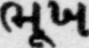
ભૂખ
